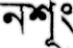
নশূং
